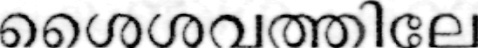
ശൈശവത്തിലേ
